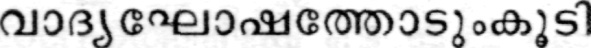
വാദ്യഘോഷത്തോടുംകൂടി
